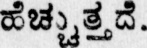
ಹೆಚ್ಚುತ್ತದೆ.
